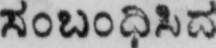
ಸಂಬಂಧಿಸಿದ
